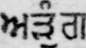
ਅੜੁੰਗ
